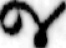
જ
